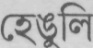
হেঙুলি
